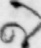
જે
